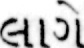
લાગે
